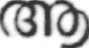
ആ
